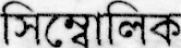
সিম্বোলিক
